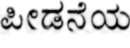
ಪೀಡನೆಯ
